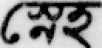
স্নেহ
